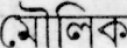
মৌলিক
